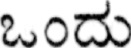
ಒಂದು
